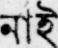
নাই
